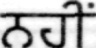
ਨਹੀਂ
